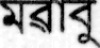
মৱাবু
